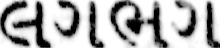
લગભગ
